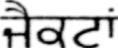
ਜੈਕਟਾਂ
